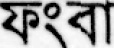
ফংবা
